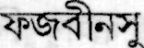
ফজবীনা
